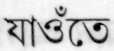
যাওঁতে
